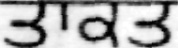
ਤਾਕਤ
